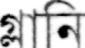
গ্লানি
